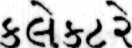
કલેક્ટરે
